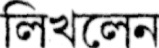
লিখলেন
